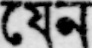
যেন
